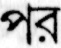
পর
